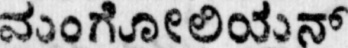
ಮಂಗೋಲಿಯನ್
